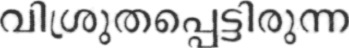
വിശ്രുതപ്പെട്ടിരുന്ന
